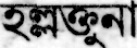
হল্লক্তুনা
